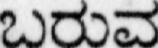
ಬರುವ
